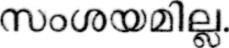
സംശയമില്ല.
